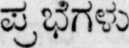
ಪ್ರಭೆಗಳು
